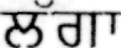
ਲੱਗਾ
